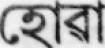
হোৱা
